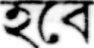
হবে
